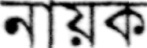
নায়ক
